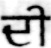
ਦੀ
